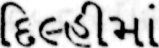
દિલ્હીમાં
